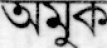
অমুক
